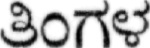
ತಿಂಗಳ
